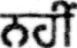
ਨਹੀਂ
